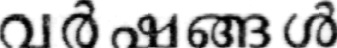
വര്‍ഷങ്ങള്‍
